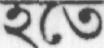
হতে
